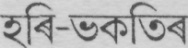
হৰি-ভকতিৰ
